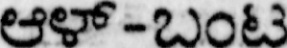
ಆಳ್-ಬಂಟ
